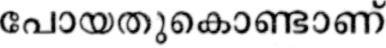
പോയതുകൊണ്ടാണ്
